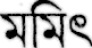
মমিৎ
